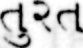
તુરત
